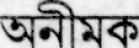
অনীমক
